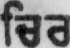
ਚਿਰ
